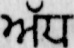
ਅੱਧ
